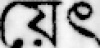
য়েৎ
